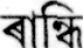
ৰান্ধি
